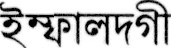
ইম্ফালদগী
